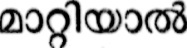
മാറ്റിയാല്‍
